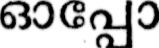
ഓപ്പോ
